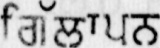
ਗਿੱਲਾਪਨ
